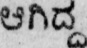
ಆಗಿದ್ದ
